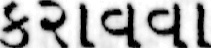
કરાવવા
